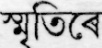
স্মৃতিৰে
